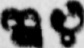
ಇಳಿ
